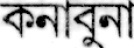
কনাবুনা
